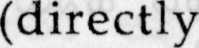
(directly
